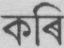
কৰি
